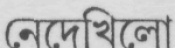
নেদেখিলো
